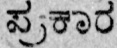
ಪ್ರಕಾರ
